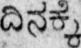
ದಿನಕ್ಕೆ
